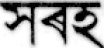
সৰহ
